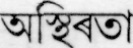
অস্থিৰতা
